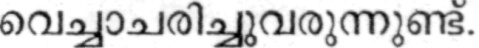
വെച്ചാചരിച്ചുവരുന്നുണ്ട്.
